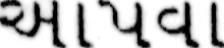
આપવા
